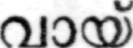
വായ്
